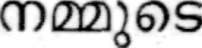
നമ്മുടെ
